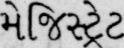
મેજિસ્ટ્રેટ
